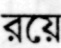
রয়ে
